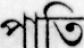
পাতি
